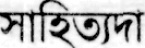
সাহিত্যদা
